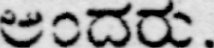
ಅಂದರು.
